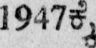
1947ಕ್ಕೆ
